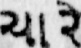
ચારે
